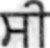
ਸੀ
